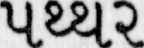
પથ્થર
